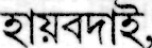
হায়বদাই,
